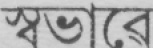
স্বভাৱে
